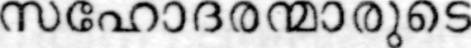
സഹോദരന്മാരുടെ
